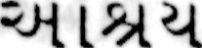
આશ્રય
